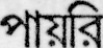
পায়রি
